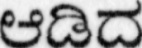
ಆಡಿದ
